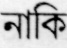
নাকি
